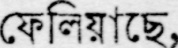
ফেলিয়াছে,
